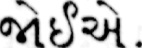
જોઈએ.
